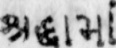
શ્રદ્ધામાં
